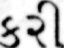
કરી
